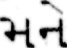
મને
